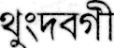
থুংদবগী
